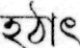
হঠাৎ
